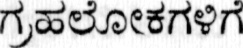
ಗ್ರಹಲೋಕಗಳಿಗೆ
